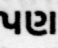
પણ
